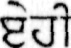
ਏਹੀ
